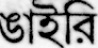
ঙাইরি
